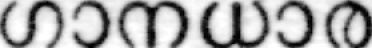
ഗാനധാര
